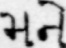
મને
